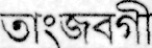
তাংজবগী
